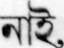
নাই,
